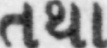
તથા
